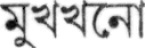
মুখখনো
